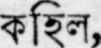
কহিল,
